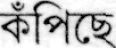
কঁপিছে
